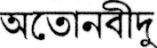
অতোনবীদু
